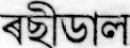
ৰছীডাল
